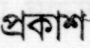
প্রকাশ
